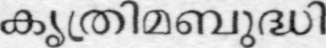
കൃത്രിമബുദ്ധി
